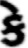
કે
